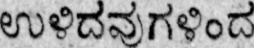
ಉಳಿದವುಗಳಿಂದ
